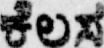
ಕೆಲಸ
